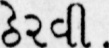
ઠેરવી.
